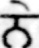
ਨੇ
